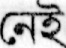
নেই
